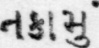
નકામું
